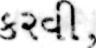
કરવી,
